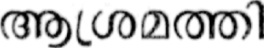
ആശ്രമത്തി
